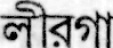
লীরগা
